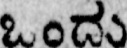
ಒಂದು
